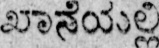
ಖಾನೆಯಲ್ಲಿ
